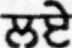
ਲਏ
